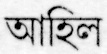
আহিল
